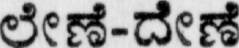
ಲೇಣೆ-ದೇಣೆ
